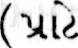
(પ્રાટે
